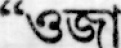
“ওজা
